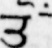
ਤੋਂ
